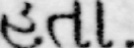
હતા.
